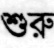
শুরু
